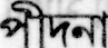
পীদনা
